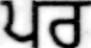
ਪਰ
